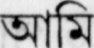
আমি
